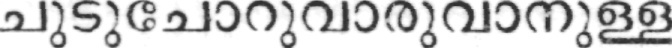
ചുടുചോറുവാരുവാനുള്ള
